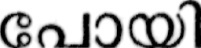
പോയി
